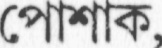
পোশাক,
